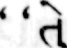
"તે
